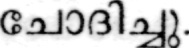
ചോദിച്ചു.
